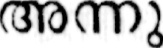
അന്നു
